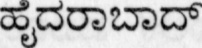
ಹೈದರಾಬಾದ್
